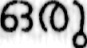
ഒരു
